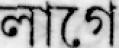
লাগে
